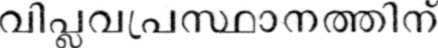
വിപ്ലവപ്രസ്ഥാനത്തിന്
